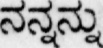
ನನ್ನನ್ನು
